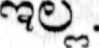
ಇಲ್ಲ.
